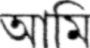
আমি
